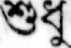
শুধু
